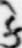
કે
